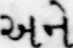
અને
